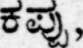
ಕಪ್ಪು,
